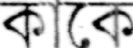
কাকে
